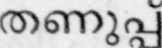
തണുപ്പ്
